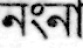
নংনা
